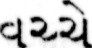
વચ્ચે
